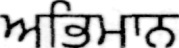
ਅਭਿਮਾਨ
